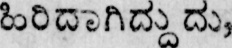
ಹಿರಿದಾಗಿದ್ದುದು,
